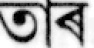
তাৰ
